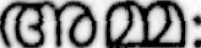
അമ്മ:
